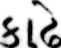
કાઢે
